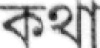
কথা
